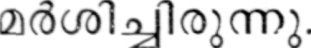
മര്‍ശിച്ചിരുന്നു.
